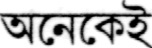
অনেকেই
